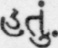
હતું.
